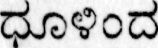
ಧೂಳಿಂದ
